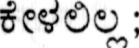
ಕೇಳಲಿಲ್ಲ;
